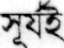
সূৰ্যই
